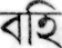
বহি
